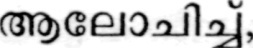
ആലോചിച്ച്,
